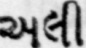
અલી
